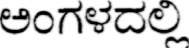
ಅಂಗಳದಲ್ಲಿ
